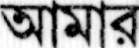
আমার
